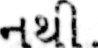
નથી.
